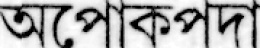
অপোকপদা
